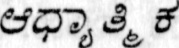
ಆಧ್ಯಾತ್ಮಿಕ
